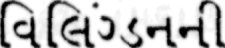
વિલિંગ્ડનની
